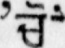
'ਚੋਂ
